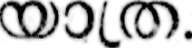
യാത്ര.
